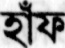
হাঁফ
